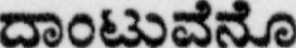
ದಾಂಟುವೆನೊ
